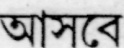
আসবে
